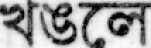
খঙলে
